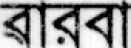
ৱারবা
